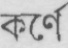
কৰ্ণে
